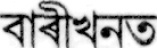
বাৰীখনত
